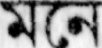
মনে
